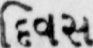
દિવસ
